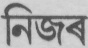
নিজৰ
